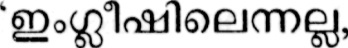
'ഇംഗ്ലീഷിലെന്നല്ല,
